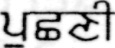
ਪੁਛਣੀ
